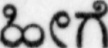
ಹೀಗೆ
